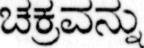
ಚಕ್ರವನ್ನು
